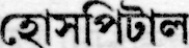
হোসপিটাল
